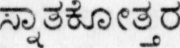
ಸ್ನಾತಕೋತ್ತರ
